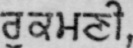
ਰੁਕਮਣੀ,
